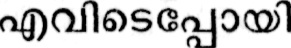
എവിടെപ്പോയി
